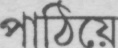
পাঠিয়ে
